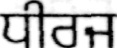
ਧੀਰਜ
